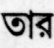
তার
